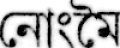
নোংমৈ
